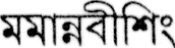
মমান্নবীশিং
